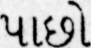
પાછો
